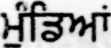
ਮੁੰਡਿਆਂ
